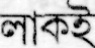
লাকই
